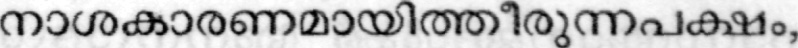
നാശകാരണമായിത്തീരുന്നപക്ഷം,
